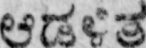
ಆಡಳಿತ
